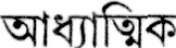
আধ্যাত্মিক
